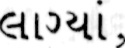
લાગ્યાં,
